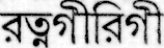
রত্নগীরিগী
